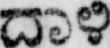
ದಾಳಿ
